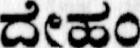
ದೇಹಂ
